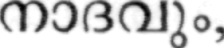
നാദവും,
